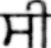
ਸੀ
